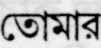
তোমার
